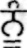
ਨੂੰ
